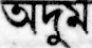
অদুম
